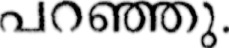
പറഞ്ഞു.
